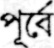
পূর্বে
